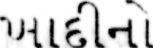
ખાદીનો
